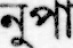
নুপা
